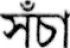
সঁচা
